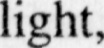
light,
